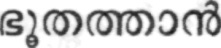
ഭൂതത്താന്‍
